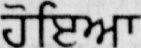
ਹੋਇਆ
